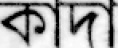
কাদা
